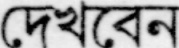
দেখবেন
